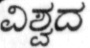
ವಿಶ್ವದ
